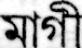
মাগী
